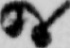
જ
